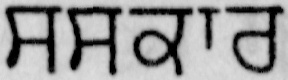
ਸਸਕਾਰ
